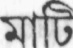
মাটি
